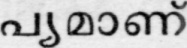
പ്യമാണ്
